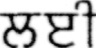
ਲਈ
